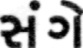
સંગે
